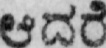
ಆದರೆ
